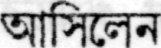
আসিলেন
